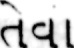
તેવા
